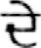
ਦੇ
